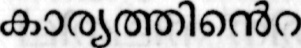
കാര്യത്തിന്റെ
